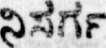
ನಿಸರ್ಗ
